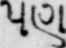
પણ
